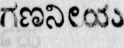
ಗಣನೀಯ
